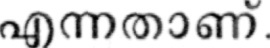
എന്നതാണ്.
